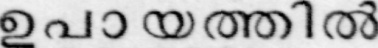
ഉപായത്തില്‍
